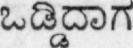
ಒಡ್ಡಿದಾಗ
